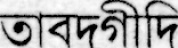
তাবদগীদি
